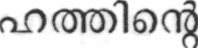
ഹത്തിന്റെ
